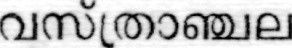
വസ്ത്രാഞ്ചല
